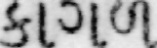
કાગળ
